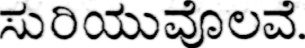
ಸುರಿಯುವೊಲವೆ.
